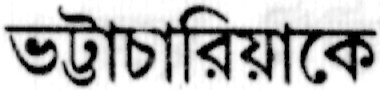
ভট্টাচারিয়াকে
